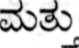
ಮತ್ತು
